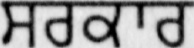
ਸਰਕਾਰ
